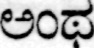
ಅಂಥ
